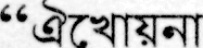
“ঐখোয়না
